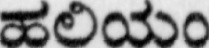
ಹಲಿಯಂ
